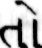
તો
